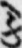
કે
